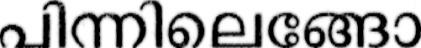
പിന്നിലെങ്ങോ
